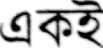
একই
